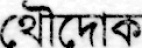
থৌদোক
